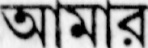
আমার
